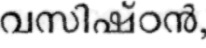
വസിഷ്ഠന്‍,
